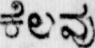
ಕೆಲವು
